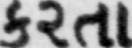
કરતા
